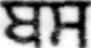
ਬਸ
